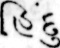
હિંદુ
